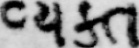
વ્યક્ત
